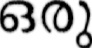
ഒരു
